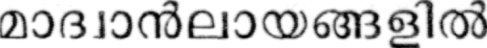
മാദ്വാന്‍ലായങ്ങളില്‍
